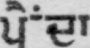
ਪੈਂਦਾ
